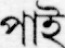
পাই
